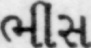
ભીંસ
